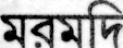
মরমদি
